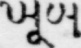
ખૂબ
